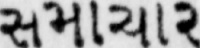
સમાચાર
